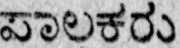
ಪಾಲಕರು
